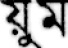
য়ুম
